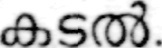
കടല്‍.
